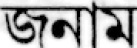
জনাম
